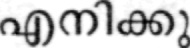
എനിക്കു
